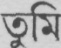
তুমি
